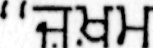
''ਜ਼ਖ਼ਮ
